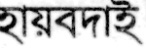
হায়বদাই
